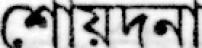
শোয়দনা
